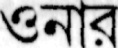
ওনার
